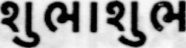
શુભાશુભ
